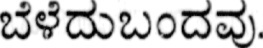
ಬೆಳೆದುಬಂದವು.
